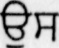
ਉਸ
